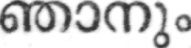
ഞാനും
